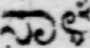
ನಾಳೆ
